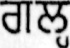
ਗਲ੍ਹ
